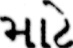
માટે
